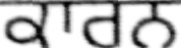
ਕਾਰਨ
